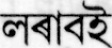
লৰাবই
